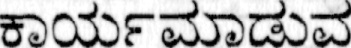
ಕಾರ್ಯಮಾಡುವ
